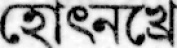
হোৎনখ্রে
